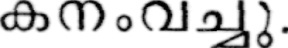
കനംവച്ചു.
